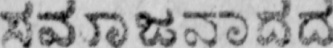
ಸಮಾಜವಾದದ
